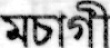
মচাগী
